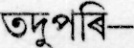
তদুপৰি-
